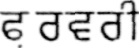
ਫ਼ਰਵਰੀ
